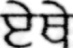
ਏਥੇ
